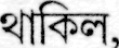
থাকিল,
